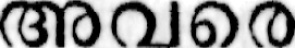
അവരെ
